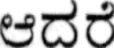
ಆದರೆ
